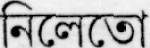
নিলেতো
